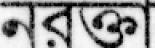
নরক্তা
